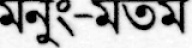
মনুং-মতম
